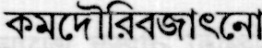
কমদৌরিবজাৎনো
